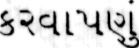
કરવાપણું
